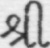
શ્રી
